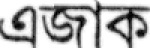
এজাক
